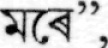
মৰে",
